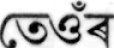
তেওঁৰ
